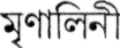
মৃণালিনী
